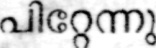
പിറ്റേന്നു
